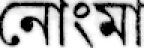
নোংমা
